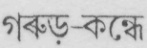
গৰুড়-কন্ধে
